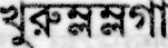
খুরুম্লম্লগা
